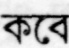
কবে
